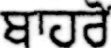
ਬਾਹਰੋਂ
